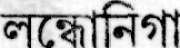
লন্ধোনিগা
